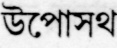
উপোসথ
